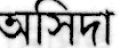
অসিদা
